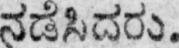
ನಡೆಸಿದರು.
